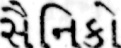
સૈનિકો
